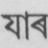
যাৰ
